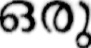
ഒരു
